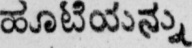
ಹೂಟೆಯನ್ನು
